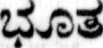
ಭೂತ
